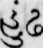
હુંઢ
